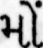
મોં
